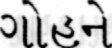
ગોહને
